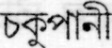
চকুপানী
